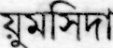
য়ুমসিদা
